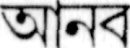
আনব
